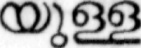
യുള്ള
